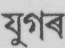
যুগৰ
